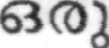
ഒരു
